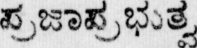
ಪ್ರಜಾಪ್ರಭುತ್ವ
